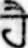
ਹੈ
